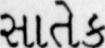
સાતેક
